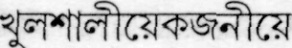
খুলশালীয়েকজনীয়ে
